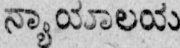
ನ್ಯಾಯಾಲಯ
